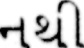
નથી
